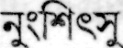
নুংশিৎসু
